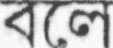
বলে
